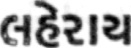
લહેરાય
